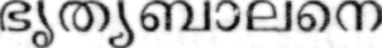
ഭൃത്യബാലനെ
